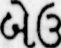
બેઉ
